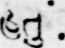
હતું.
